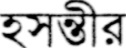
হসন্তীর
